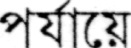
পর্যায়ে
